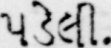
પડેલી.
